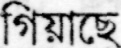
গিয়াছে
